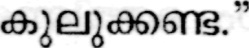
കുലുക്കണ്ട."
